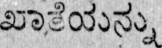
ಖಾತೆಯನ್ನು
